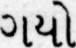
ગયો
